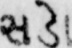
સડો
